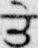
ਤੇ
